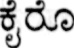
ಕೈರೊ
